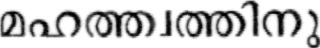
മഹത്ത്വത്തിനു
